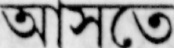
আসতে
